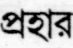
প্রহার
